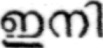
ഇനി
